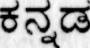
ಕನ್ನಡ
